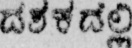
ದಶಕದಲ್ಲಿ
